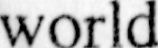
world
